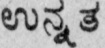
ಉನ್ನತ
